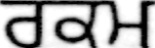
ਰਕਮ
